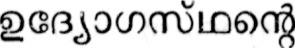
ഉദ്യോഗസ്ഥന്റെ
